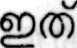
ഇത്
